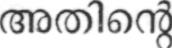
അതിന്റെ
